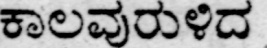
ಕಾಲವುರುಳಿದ
